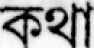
কথা
